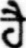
ਹੈ
